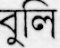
বুলি
